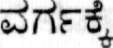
ವರ್ಗಕ್ಕೆ
